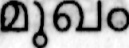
മുഖം
